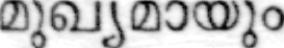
മുഖൃമായും
